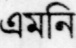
এমনি
